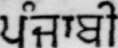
ਪੰਜਾਬੀ
